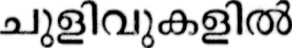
ചുളിവുകളില്‍
